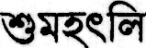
শুমহৎলি
